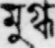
মুগ্ধ
